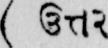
(ઉત્તર
